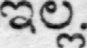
ಇಲ್ಲ.
